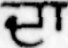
ਦਾ
